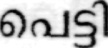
പെട്ടി
